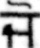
ਜੋ
